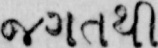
જગતથી
